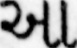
આ
